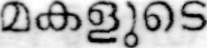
മകളുടെ
